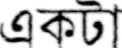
একটা
